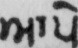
ਆਪੇ
